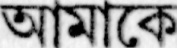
আমাকে
